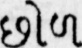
છોળ
